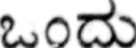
ಒಂದು
